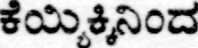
ಕೆಯ್ಯಿಕ್ಕಿನಿಂದ
